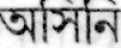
অসিনি
